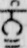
ਨੂੰ
